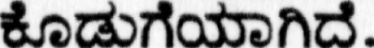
ಕೊಡುಗೆಯಾಗಿದೆ.
